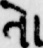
નો
